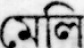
মেলি
